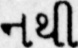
નથી
